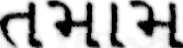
તમામ
